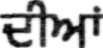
ਦੀਆਂ
